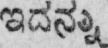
ಇದನ್ನು
